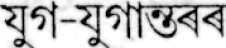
যুগ-যুগান্তৰৰ
